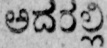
ಅದರಲ್ಲಿ
